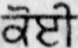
ਕੋਈ
